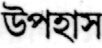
উপহাস
